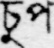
চুপ
